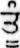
ਤੂੰ
